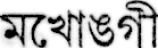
মখোঙগী
